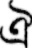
ঐ
